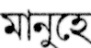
মানুহে
